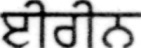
ਈਰੀਨ
